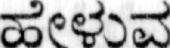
ಹೇಳುವ
